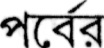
পর্বের
